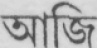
আজি
